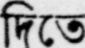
দিতে
